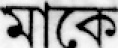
মাকে
